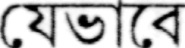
যেভাবে
